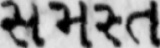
સમસ્ત
